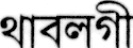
থাবলগী
